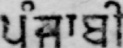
ਪੰਜਾਬੀ
